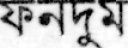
ফনদুম
